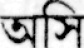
অসি
